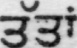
ਤੱਤਾਂ
